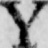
Y
